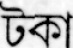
টকা
